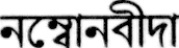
নম্বোনবীদা
